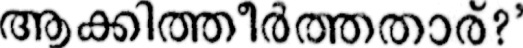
ആക്കിത്തീര്‍ത്തതാര്?’
